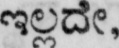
ಇಲ್ಲದೇ,
